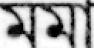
মামা
